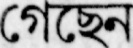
গেছেন
